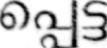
പ്പെട്ട
